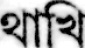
থাখি
